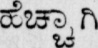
ಹೆಚ್ಚಾಗಿ
